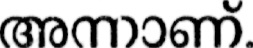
അന്നാണ്.
